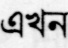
এখন
